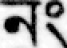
নং
